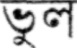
ভুল
